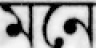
মনে
